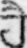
ਹੈ
